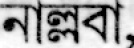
নাল্লবা,
